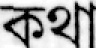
কথা
